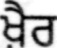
ਖ਼ੈਰ
